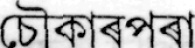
চৌকাৰপৰা
